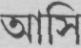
আসি
